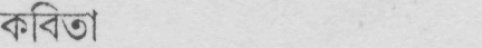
কবিতা
